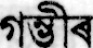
গম্ভীৰ
